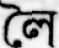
লৈ
